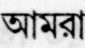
আমরা
